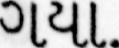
ગયા.
